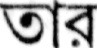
তার
